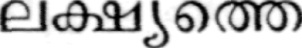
ലക്ഷ്യത്തെ
